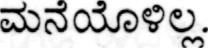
ಮನೆಯೊಳಿಲ್ಲ.
